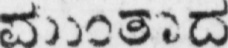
ಮುಂತಾದ
